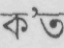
ক'ত
